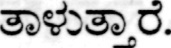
ತಾಳುತ್ತಾರೆ.
